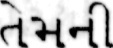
તેમની
